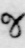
જ
